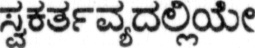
ಸ್ವಕರ್ತವ್ಯದಲ್ಲಿಯೇ
